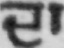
ਦਾ
